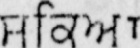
ਸਕਿਆ
